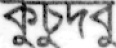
কুচুদবু
